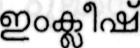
ഇംക്ലീഷ്
